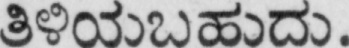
ತಿಳಿಯಬಹುದು.
